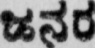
ಜನರ
